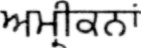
ਅਮ੍ਰੀਕਨਾਂ
